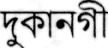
দুকানগী
